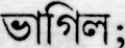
ভাগিল;
